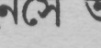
নসে
